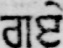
ਗਏ
